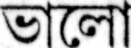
ভালো
